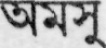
অমসু
